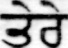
ਤੇਰੇ
